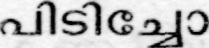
പിടിച്ചോ
